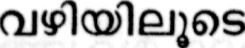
വഴിയിലൂടെ
